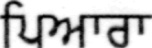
ਪਿਆਰਾ
